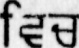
ਵਿਚ
